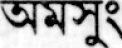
অমসুং
